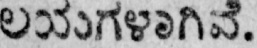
ಲಯಗಳಾಗಿವೆ.
